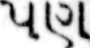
પણ
